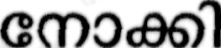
നോക്കി
